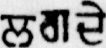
ਲਗਦੇ
